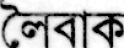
লৈবাক
